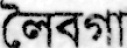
লৈবগা
